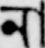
না
